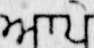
ਆਪੇ
